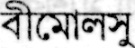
বীমোলসু
